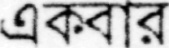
একবার
